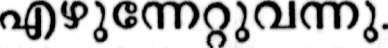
എഴുന്നേറ്റുവന്നു.
